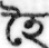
হৈ
